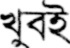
খুবই
